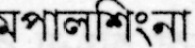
মপালশিংনা
